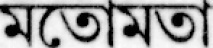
মতোমতা
